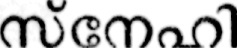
സ്നേഹി
